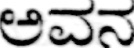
ಅವನ
